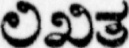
ಲಿಖಿತ
